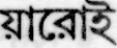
য়ারোই
